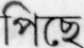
পিছে
